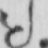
ઇ.
